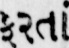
ફરતાં
